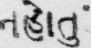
નહોતું
